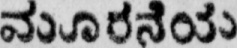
ಮೂರನೆಯ
